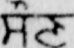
ਸੌਣ
